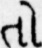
તો
